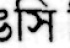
ঙসি
